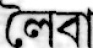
লৈবা
